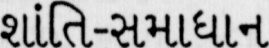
શાંતિ-સામાધાન
